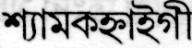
শ্যামকহ্ণাইগী
